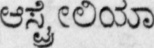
ಆಸ್ಟ್ರೇಲಿಯಾ
